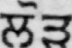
ਲੋੜ
